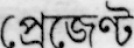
প্রেজেণ্ট
